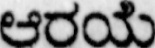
ಆರಯೆ
